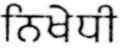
ਨਿਖੇਧੀ
